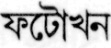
ফটোখন
